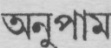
অনুপাম
